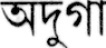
অদুগা
